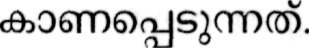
കാണപ്പെടുന്നത്.
